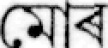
মোৰ
